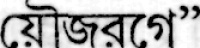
য়ৌজরগে”
